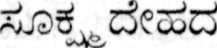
ಸೂಕ್ಷ್ಮದೇಹದ
